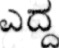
ಎದ್ದ
